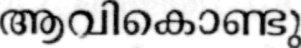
ആവികൊണ്ടു
